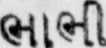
ભાભી
